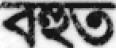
বহুত
